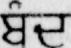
ਬੰਦ
